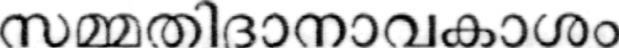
സമ്മതിദാനാവകാശം
